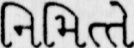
નિમિત્તે
